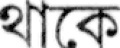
থাকে
